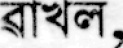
ৱাখল,
